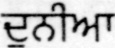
ਦੁਨੀਆ
